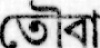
তৌবা
